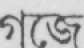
গজে
